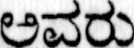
ಅವರು
